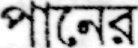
পানের
